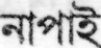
নাপাই
